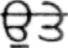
ਉਤੇ
